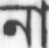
না
